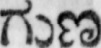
ಗುಣ
